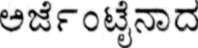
ಅರ್ಜೆಂಟೈನಾದ
